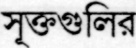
সূক্তগুলির
